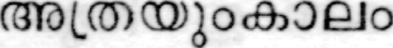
അത്രയുംകാലം
